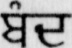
ਬੰਦ
